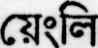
য়েংলি
